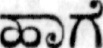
ಹಾಗೆ
